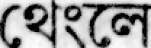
থেংলে
